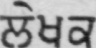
ਲੇਖਕ
